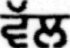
ਵੱਲ
